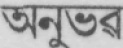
অনুভৱ
